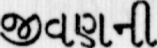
જીવણની
